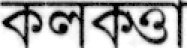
কলকত্তা
